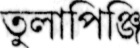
তুলাপিঞ্জি
